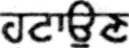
ਹਟਾਉਣ
